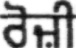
ਰੋਜ਼ੀ
